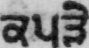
ਕਪੜੇ
